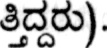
ತ್ತಿದ್ದರು).
